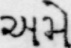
અમે
